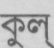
কুল্
